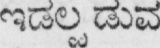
ಇಡಲ್ಪಡುವ
